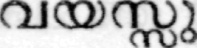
വയസ്സു
